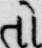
તો
